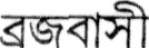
ব্রজবাসী
